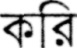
করি
